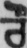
ਰੌ
